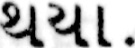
થયા.
